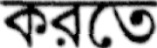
করতে
